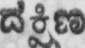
ದಕ್ಷಿಣ
